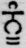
ਨੂੰ
